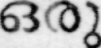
ഒരു
